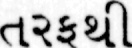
તરફથી
